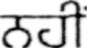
ਨਹੀਂ
